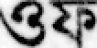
ওফ
